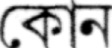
কোন
